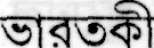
ভারতকী
